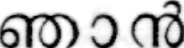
ഞാന്‍
